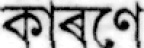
কাৰণে
